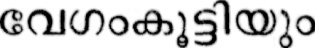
വേഗംകൂട്ടിയും
